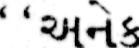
"અનેક
